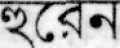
হুরেন
